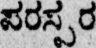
ಪರಸ್ಪರ
